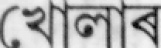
খোলাৰ
